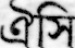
ঐসি
